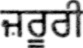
ਜ਼ਰੂਰੀ
